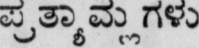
ಪ್ರತ್ಯಾಮ್ಲಗಳು
